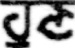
ਹੁਣ
